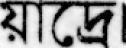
য়াদ্রে।
